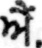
ਐਂ,
